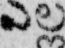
ಎಲ್ಲ
